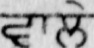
ਵਾਲੇ
